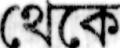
থেকে
